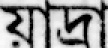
য়াদ্রা
